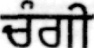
ਚੰਗੀ
